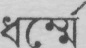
ধৰ্ম্মে
